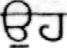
ਉਹ
